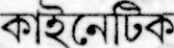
কাইনেটিক
